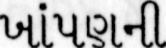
ખાંપણની
